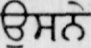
ਉਸਨੇ
